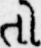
તો
